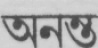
অনন্ত
